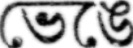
ভেঙে
